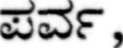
ಪರ್ವ,
